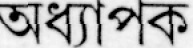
অধ্যাপক
